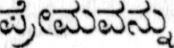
ಪ್ರೇಮವನ್ನು
